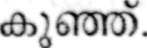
കുഞ്ഞ്.
